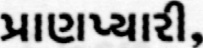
પ્રાણપ્યારી
